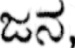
ಜನ,
